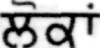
ਲੋਕਾਂ
